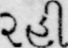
રહી
